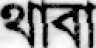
থাবা
